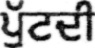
ਪੁੱਟਦੀ
